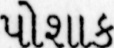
પોશાક
